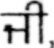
ਜੀ,
